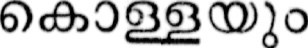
കൊള്ളയും
